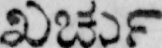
ಖರ್ಚು
